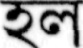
হল
